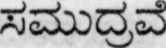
ಸಮುದ್ರವೆ
